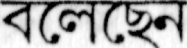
বলেছেন
